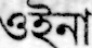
ওইনা
